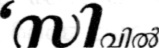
‘സിവില്‍
